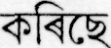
কৰিছে
